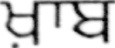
ਖ਼ਾਬ
